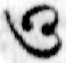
ও
